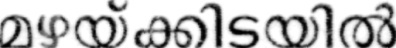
മഴയ്ക്കിടയില്‍
